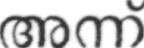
അന്ന്
